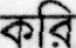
করি
